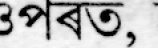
ওপৰত,
